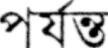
পর্যন্ত
